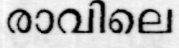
രാവിലെ
